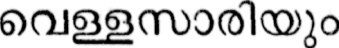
വെള്ളസാരിയും
